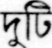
দুটি
